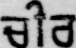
ਚੀਰ
